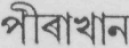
পীৰাখান
